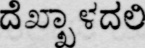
ದೆಖ್ಖಾಳದಲಿ
